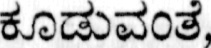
ಕೂಡುವಂತೆ,
